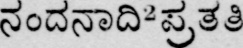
ನಂದನಾದಿ2ಪ್ರತತಿ
